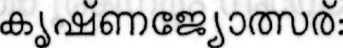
കൃഷ്ണജ്യോത്സര്:
